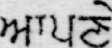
ਆਪਣੇ
